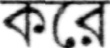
করে
